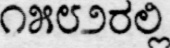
೧೫೮೨ರಲ್ಲಿ
